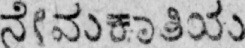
ನೇಮಕಾತಿಯ
